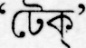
'টেক্‌'
